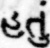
હતું
